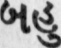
બહુ
